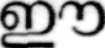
ഈ
